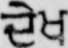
ਦੇਖ
